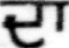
ਦਾ
